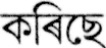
কৰিছে
